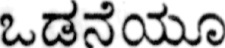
ಒಡನೆಯೂ
